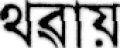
থৱায়
